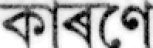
কাৰণে
